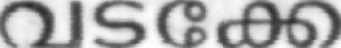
വടക്കേ
